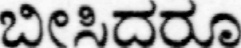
ಬೀಸಿದರೂ
